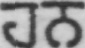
ਹਨ
